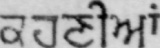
ਕਹਣੀਆਂ
